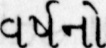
વર્ષનો
